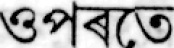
ওপৰতে
